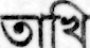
তাখি
